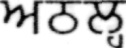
ਅਠਲ੍ਹ
